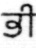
ਭੀ
